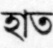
হাত
